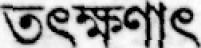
তৎক্ষণাৎ
